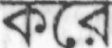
করে
